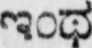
ಇಂಥ
